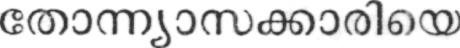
തോന്ന്യാസക്കാരിയെ
